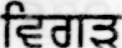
ਵਿਗੜ
